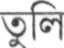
তুলি
